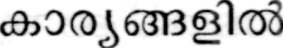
കാര്യങ്ങളില്‍
